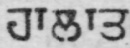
ਹਾਲਾਤ
